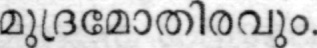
മുദ്രമോതിരവും.
